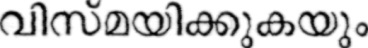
വിസ്മയിക്കുകയും
